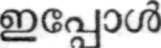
ഇപ്പോള്‍
